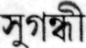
সুগন্ধী
